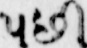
પછી
